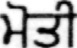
ਮੋਤੀ
